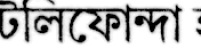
টেলিফোন্দা
